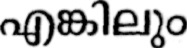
എങ്കിലും
